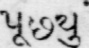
પૂછ્યું
